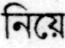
নিয়ে
